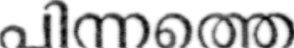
പിന്നത്തെ
